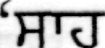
'ਸਾਹ
